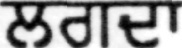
ਲਗਦਾ
